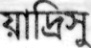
য়াদ্রিসু
